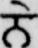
ਨੇ
